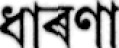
ধাৰণা
